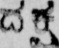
ದಕ್ಷ
